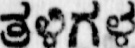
ತಳಿಗಳ
